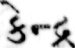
કેન્દ્ર
